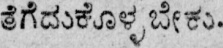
ತೆಗೆದುಕೊಳ್ಳಬೇಕು.
